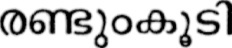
രണ്ടുംകൂടി
